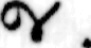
જ.
